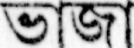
ভাজা
